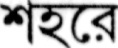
শহরে
